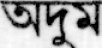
অদুম
